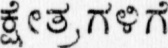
ಕ್ಷೇತ್ರಗಳಿಗೆ
